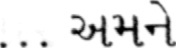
...અમને
